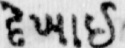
દેખાઈ
